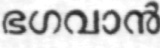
ഭഗവാന്‍
